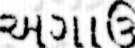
અગાઉ
